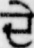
ਦੇ
